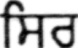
ਸਿਰ
